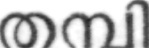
തമ്പി
